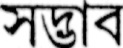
সদ্ভাব
